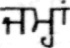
ਜਮ੍ਹਾਂ
